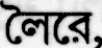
লৈরে,
